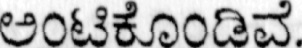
ಅಂಟಿಕೊಂಡಿವೆ.
